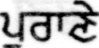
ਪੁਰਾਣੇ
